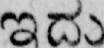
ಇದು
